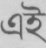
এই
